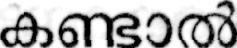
കണ്ടാല്‍
